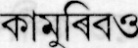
কামুৰিবও
